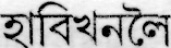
হাবিখনলৈ
